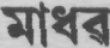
মাধৱ
